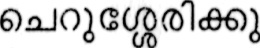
ചെറുശ്ശേരിക്കു
